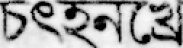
চৎহনখ্রে
